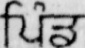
ਪਿੰਡ
